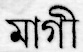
মাগী
